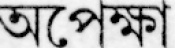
অপেক্ষা
